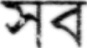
সব
